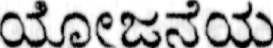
ಯೋಜನೆಯ
